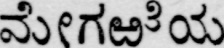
ಮೇಗಱೆಯ
